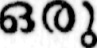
ഒരു
